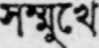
সম্মুখে
